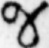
જ
